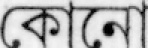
কোনো
